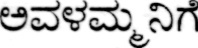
ಅವಳಮ್ಮನಿಗೆ
